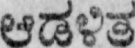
ಆಡಳಿತ
